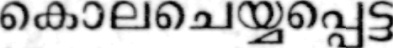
കൊലചെയ്യപ്പെട്ട
